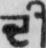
ਦੀ
